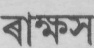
ৰাক্ষস
